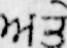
ਅਤੇ
